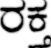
ರಕ್ತ
